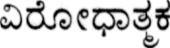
ವಿರೋಧಾತ್ಮಕ
